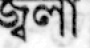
জ্বলা
